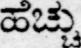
ಹೆಚ್ಚು
